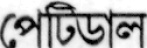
পেটিডাল
